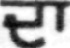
ਦਾ
